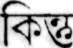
কিন্তু
